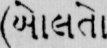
(બોલતો
